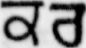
ਕਰ
